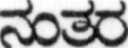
ನಂತರ
